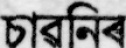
চাৱনিৰ
